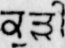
ਕੁੜੀ
